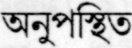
অনুপস্থিত
